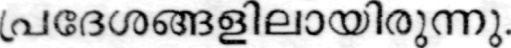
പ്രദേശങ്ങളിലായിരുന്നു.
